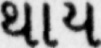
થાય
